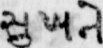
સુખને
